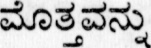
ಮೊತ್ತವನ್ನು
